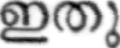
ഇതു
